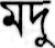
মদু
